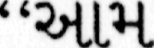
"આમ
